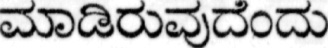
ಮಾಡಿರುವುದೆಂದು
